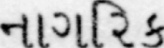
નાગરિક
